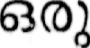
ഒരു
